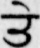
ਤੇ
